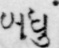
બધું
